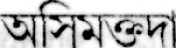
অসিমক্তদা
